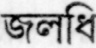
জলধি
